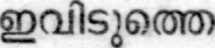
ഇവിടുത്തെ
